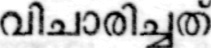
വിചാരിച്ചത്
